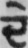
ਦੇ
